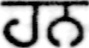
ਹਨ
